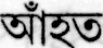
আঁহত
